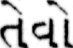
તેવો
